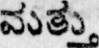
ಮತ್ತು
